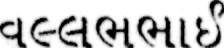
વલ્લભભાઈ
